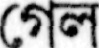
গেল
